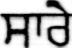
ਸਾਰੇ
